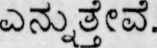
ಎನ್ನುತ್ತೇವೆ.
